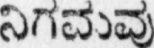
ನಿಗಮವು
